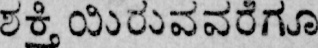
ಶಕ್ತಿಯಿರುವವರೆಗೂ
